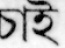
চাই
